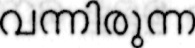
വന്നിരുന്ന
